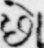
છો
